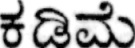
ಕಡಿಮೆ
